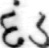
દંડ
